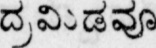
ದ್ರಮಿಡವೂ
